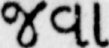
જવા
